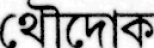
থৌদোক
